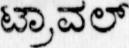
ಟ್ರಾವಲ್
